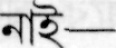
নাই-
